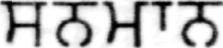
ਸਨਮਾਨ
